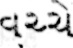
વચ્ચે
